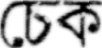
চেক
